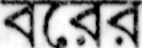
বরের
